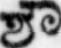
ಶೌ
